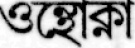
ওন্থোক্না
